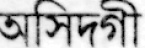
অসিদগী
